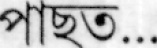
পাছত...
